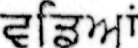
ਵਡਿਆਂ
